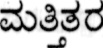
ಮತ್ತಿತರ
